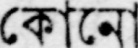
কোনো
